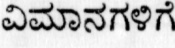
ವಿಮಾನಗಳಿಗೆ
